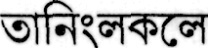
তানিংলকলে
